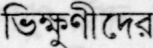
ভিক্ষুণীদের
